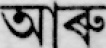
আৰু
